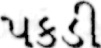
પકડી
